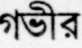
গভীর
